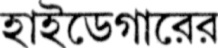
হাইডেগারের
